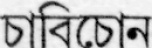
চাবিচোন
